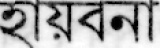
হায়বনা
